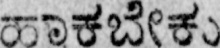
ಹಾಕಬೇಕು
